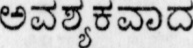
ಅವಶ್ಯಕವಾದ
